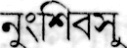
নুংশিবসু
